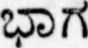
ಭಾಗ
